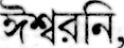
ঈশ্বরনি,
